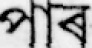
পাৰ
